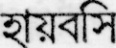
হায়বসি
